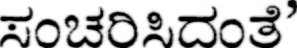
ಸಂಚರಿಸಿದಂತೆ'
